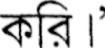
করি।'
